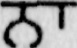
ਨਾ
